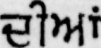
ਦੀਆਂ
